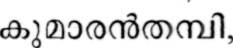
കുമാരന്‍തമ്പി,
